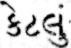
કેટલું
